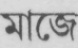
মাজে
